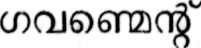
ഗവണ്മെന്റ്
